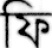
ফি
